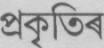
প্রকৃতিৰ
